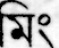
মিং
